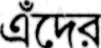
এঁদের
